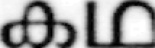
കഥ
